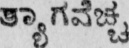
ತ್ಯಾಗವೆಚ್ಚ
